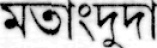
মতাংদুদা
